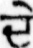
ਦੇ
